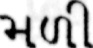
મળી
